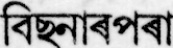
বিছনাৰপৰা
